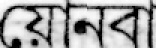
য়োনবা
